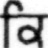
ਕਿ
